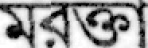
মরক্তা
